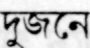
দুজনে
